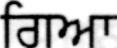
ਗਿਆ
